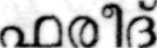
ഫരീദ്
